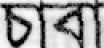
চাবা
